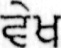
ਵੇਖ
